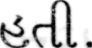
હતી.
